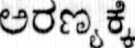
ಅರಣ್ಯಕ್ಕೆ
